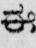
ಈ
